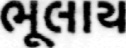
ભૂલાય
